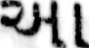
આ
